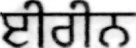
ਈਰੀਨ
